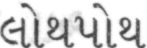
લોથપોથ
